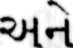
અને
